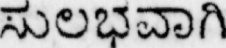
ಸುಲಭವಾಗಿ
